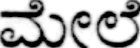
ಮೇಲೆ
